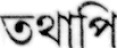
তথাপি
